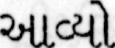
આવ્યો
